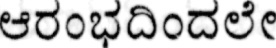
ಆರಂಭದಿಂದಲೇ
